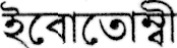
ইবোতোম্বী
